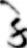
કે
